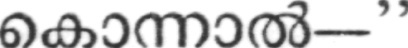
കൊന്നാല്‍-"
